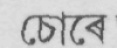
চোৰে
